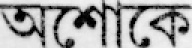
অশোকে
